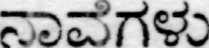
ನಾವೆಗಳು
